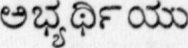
ಅಭ್ಯರ್ಥಿಯು
